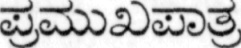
ಪ್ರಮುಖಪಾತ್ರ
